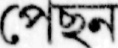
পেছন
